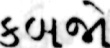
કબજો
